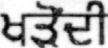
ਖੜੋਂਦੀ
